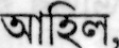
আহিল,
